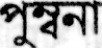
পুম্বনা
